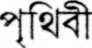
পৃথিবী
